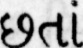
છતાં
